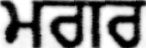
ਮਗਰ
